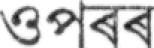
ওপৰৰ
